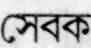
সেবক
